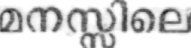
മനസ്സിലെ
